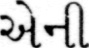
એની
